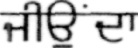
ਜੀਉਂਦਾ
